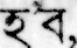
হ'ব,
